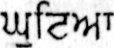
ਘੁਟਿਆ
